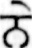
ਨੇ
